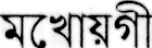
মখোয়গী
